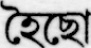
হৈছো
